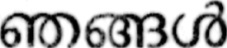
ഞങ്ങള്‍
